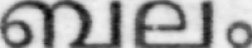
ബലം
